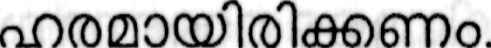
ഹരമായിരിക്കണം.
